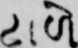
ટાળે
